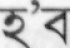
হ'ব
